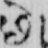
છો
